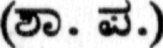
(ಶಾ.ಪ.)
